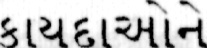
કાયદાઓને
